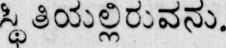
ಸ್ಥಿತಿಯಲ್ಲಿರುವನು.
